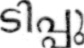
ടിപ്പു
